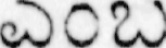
ಎಂಬ
